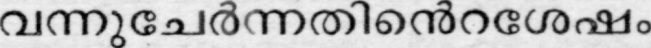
വന്നുചേര്‍ന്നതിന്റെശേഷം
